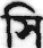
সি
